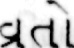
વ્રતો
